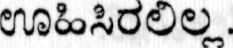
ಊಹಿಸಿರಲಿಲ್ಲ.
